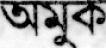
অমুক
